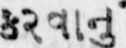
કરવાનું
